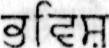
ਭਵਿਸ਼
